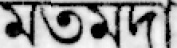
মতমদা
